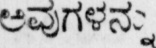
ಅವುಗಳನ್ನು
